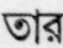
তার
